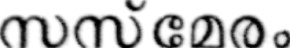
സസ്മേരം
